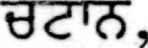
ਚਟਾਨ,
